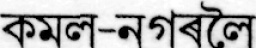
কমল-নগৰলৈ
